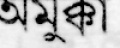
অমুক্কা
